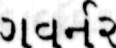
ગવર્નર
